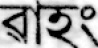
ৱাহং
